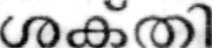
ശക്തി
